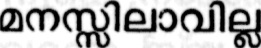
മനസ്സിലാവില്ല
